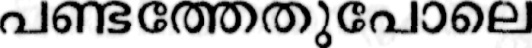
പണ്ടത്തേതുപോലെ
